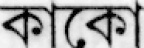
কাকো
